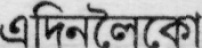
এদিনলৈকো
